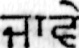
ਜਾਵੇ
